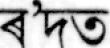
ৰ'দত
